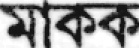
মাকক
